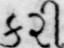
કરી
